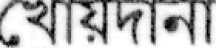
খোয়দানা
